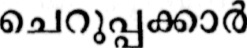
ചെറുപ്പക്കാര്‍
